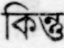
কিন্তু
